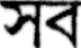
সব
